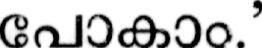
പോകാം.'
